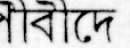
পীবীদে
